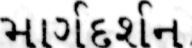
માર્ગદર્શન
